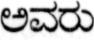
ಅವರು
